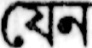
যেন
